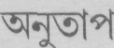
অনুতাপ
